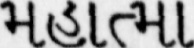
મહાત્મા
